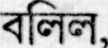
বলিল,
